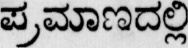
ಪ್ರಮಾಣದಲ್ಲಿ
